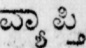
ವ್ಯಾಪ್ತಿ
